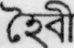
হৈবী
